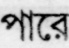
পারে
